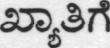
ಖ್ಯಾತಿಗೆ
